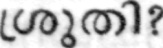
ശ്രുതി?
